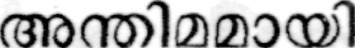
അന്തിമമായി
